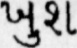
ખુશ
